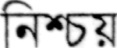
নিশ্চয়
